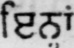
ਇਨ੍ਹਾਂ
